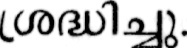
ശ്രദ്ധിച്ചു.
